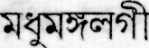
মধুমঙ্গলগী
